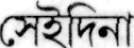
সেইদিনা
